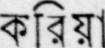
করিয়া
